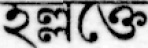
হল্লক্তে
